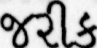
જરીક
